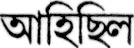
আহিছিল
